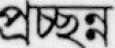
প্রচ্ছন্ন
